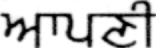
ਆਪਣੀ
